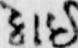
કોઈ
